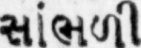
સાંભળી
